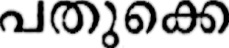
പതുക്കെ
